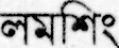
লমশিং
